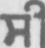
ਸੀ
